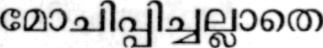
മോചിപ്പിച്ചല്ലാതെ
